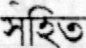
সহিত
